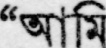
‘‘আমি
